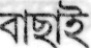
বাছাই
